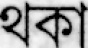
থকা
